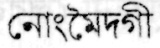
নোংমৈদগী
